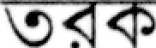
তরক
